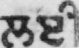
ਲਈ
